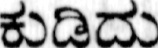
ಕುಡಿದು
